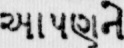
આપણને
